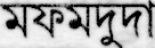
মফমদুদা
